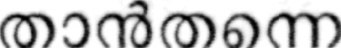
താന്‍തന്നെ
